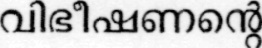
വിഭീഷണന്റെ
